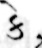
કે,
